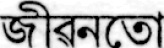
জীৱনতো
